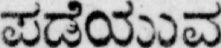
ಪಡೆಯುವ
